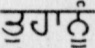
ਤੁਹਾਨੂੰ
